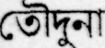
তৌদুনা
